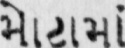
મોટામાં
